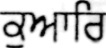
ਕੁਆਰਿ
